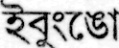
ইবুংঙো
